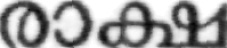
രാക്ഷ
